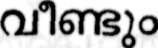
വീണ്ടും
